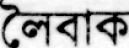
লৈবাক
